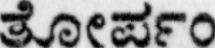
ತೋರ್ಪಂ
